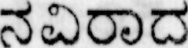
ನವಿರಾದ
